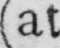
(at
